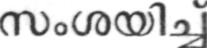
സംശയിച്ച്
